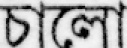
চালো
